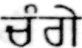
ਚੰਗੇ
